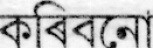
কৰিবনো
